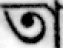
তা
